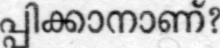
പ്പിക്കാനാണ്?
